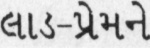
લાડ-પ્રેમને
